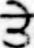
ਤੇ
